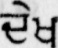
ਦੇਖ
